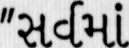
"સર્વમાં
